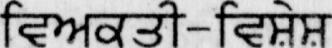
ਵਿਅਕਤੀ-ਵਿਸ਼ੇਸ਼
